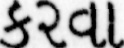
કરવા
